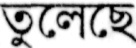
তুলেছে
